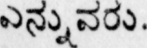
ಎನ್ನುವರು.
